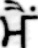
ਮੈਂ
